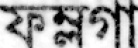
ফম্লগা
